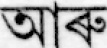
আৰু
